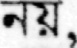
নয়,
